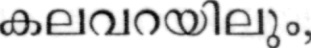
കലവറയിലും,
